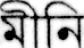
মীনি
